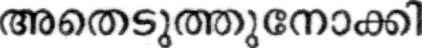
അതെടുത്തുനോക്കി
